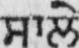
ਸਾਲੇ
